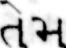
તેમ
